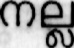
നല്ല
